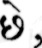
છે,
